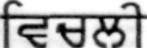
ਵਿਚਲੀ
